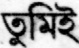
তুমিই
